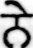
ਨੇ
